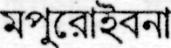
মপুরোইবনা
